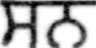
ਸਨ
